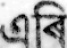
এৰি
